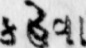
કહેવા
